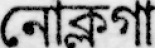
নোক্লগা
